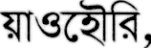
য়াওহৌরি,
